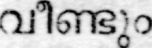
വീണ്ടും
